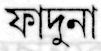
ফাদুনা
